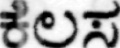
ಕೆಲಸ
